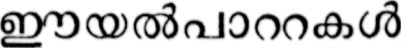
ഈയല്‍പാററകള്‍
